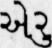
એરુ
